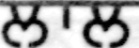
ਲਾਲ
